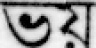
ভয়
